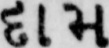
દામ
